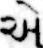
એ
